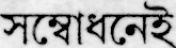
সম্বোধনেই
